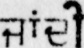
ਜਾਂਦੀ
